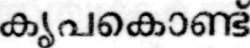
കൃപകൊണ്ട്
